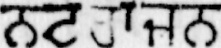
ਨਟਰਾਜਨ
